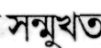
সন্মুখত
